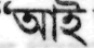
"আই
